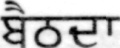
ਬੈਠਦਾ
